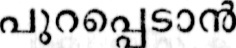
പുറപ്പെടാന്‍
